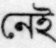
নেই
